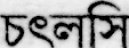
চৎলসি
